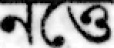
নত্তে
